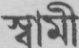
স্বামী
